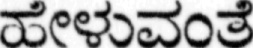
ಹೇಳುವಂತೆ
